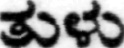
ತುಳು
